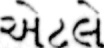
એટલે
